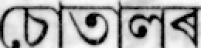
চোতালৰ
